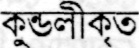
কুন্ডলীকৃত
